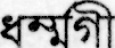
ধর্ম্মগী
